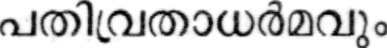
പതിവ്രതാധര്‍മവും
